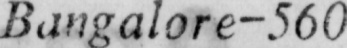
Bangalore-560
